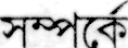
সম্পর্কে
